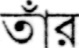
তাঁর
